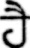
ਹੈ
